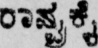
ರಾಷ್ಟ್ರಕ್ಕೆ
